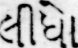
લીધો
